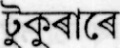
টুকুৰাৰে
